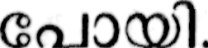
പോയി.
